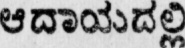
ಆದಾಯದಲ್ಲಿ
